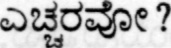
ಎಚ್ಚರವೋ?
